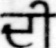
ਦੀ
